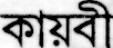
কায়বী
